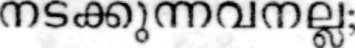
നടക്കുന്നവനല്ല;
